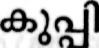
കുപ്പി
